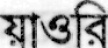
য়াওরি
